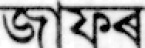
জাফৰ
